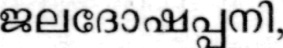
ജലദോഷപ്പനി,
